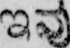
ಇವು
